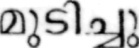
മുടിച്ചു
